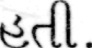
હતી.
